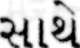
સાથે
